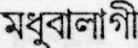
মধুবালাগী
